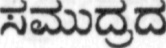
ಸಮುದ್ರದ
